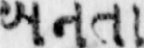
બનતા
